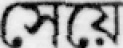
সেয়ে
